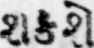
સકશે
